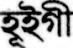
হূইগী
